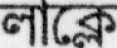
লাক্লে
